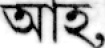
আহ,
